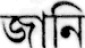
জানি
